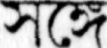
সঙ্গে
